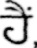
ਹੈਂ,
